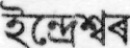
ইন্দ্ৰেশ্বৰ
